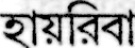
হায়রিবা
